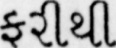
ફરીથી
